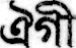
ঐগী
